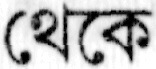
থেকে
